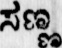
ಸಣ್ಣ
